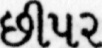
છીપર
